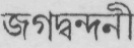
জগদ্বন্দনী
